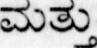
ಮತ್ತು
